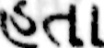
હતા
